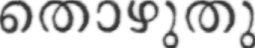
തൊഴുതു
